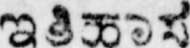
ಇತಿಹಾಸ
